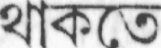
থাকতে
